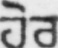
ਹੋਰ
